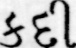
કદી
